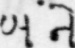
બંને
